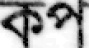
কপ
